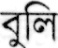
বুলি
